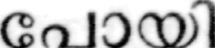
പോയി
